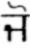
ਜੋ
